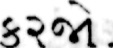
કરજો.
